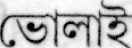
ভোলাই
